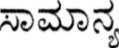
ಸಾಮಾನ್ಯ
